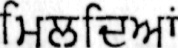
ਮਿਲਦਿਆਂ
